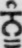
ਨੂੰ
